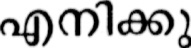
എനിക്കു
